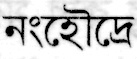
নংহৌদ্রে
